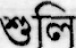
শুলি
